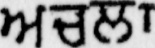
ਅਚਲਾ
